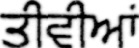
ਤੀਵੀਆਂ
